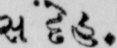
સંદેહ.
